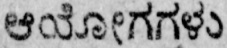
ಆಯೋಗಗಳು
